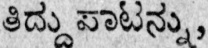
ತಿದ್ದುಪಾಟನ್ನು,
